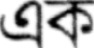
এক
